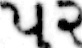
પર
